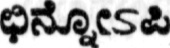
ಛಿನ್ನೋsಪಿ
